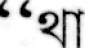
“থা
